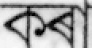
কৰা
